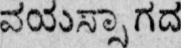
ವಯಸ್ಸಾಗದ
